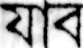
যাব
